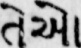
તેઓ
